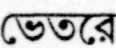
ভেতরে
